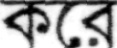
করে
